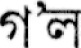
গ'ল
